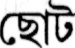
ছোট
